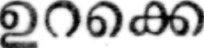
ഉറക്കെ
